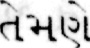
તેમણે
